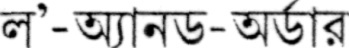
ল’-অ্যানড-অর্ডার
